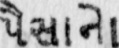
પૈસાનો
